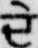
ਦੇ
